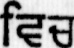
ਵਿਚ
